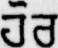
ਹੋਰ
